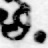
છે.
